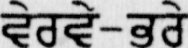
ਵੇਰਵੇ-ਭਰੇ
